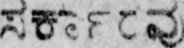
ಸರ್ಕಾರವು
